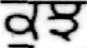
ਕੁਝ
